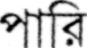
পারি
